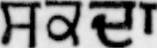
ਸਕਦਾ
